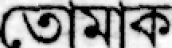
তোমাক
